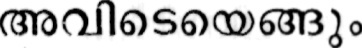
അവിടെയെങ്ങും
